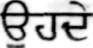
ਉਹਦੇ
